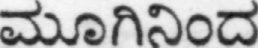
ಮೂಗಿನಿಂದ
